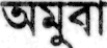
অমুবা
